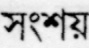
সংশয়
